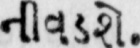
નીવડશે.
